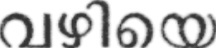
വഴിയെ
